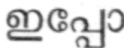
ഇപ്പോ
